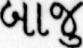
બાજુ
